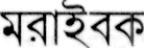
মরাইবক
